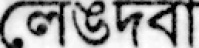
লেঙদবা
